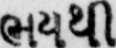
ભયની
